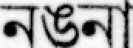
নঙনা
